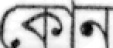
কোন
